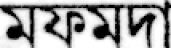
মফমদা
